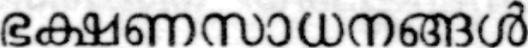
ഭക്ഷണസാധനങ്ങള്‍
